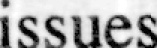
issues
